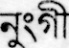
নুংগী
